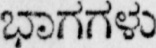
ಭಾಗಗಳು
